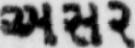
અસર
